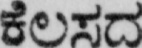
ಕೆಲಸದ
